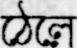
ঠেলে
